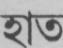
হাত
